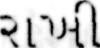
રાખી
